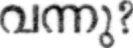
വന്നു?
